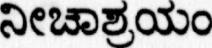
ನೀಚಾಶ್ರಯಂ
